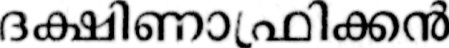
ദക്ഷിണാഫ്രിക്കന്‍
